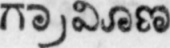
ಗ್ರಾಮೀಣ
